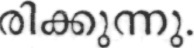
രിക്കുന്നു.
